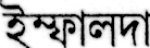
ইম্ফালদা
